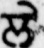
ਲੇ
